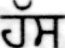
ਹੱਸ
